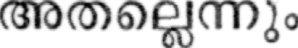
അതല്ലെന്നും
